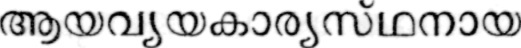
ആയവ്യയകാര്യസ്ഥനായ
